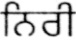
ਨਿਰੀ
